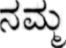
ನಮ್ಮ
